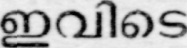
ഇവിടെ
